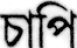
চাপি
